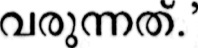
വരുന്നത്.'
